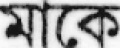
মাকে
